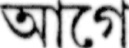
আগে
